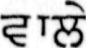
ਵਾਲੇ
